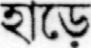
হাড়ে
